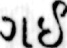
ગઈ
